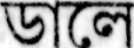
ডালে
